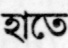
হাতে
